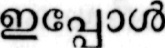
ഇപ്പോള്‍
